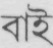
বাই
